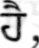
ਹੈ,
